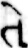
તે
